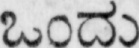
ಒಂದು
